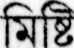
মিষ্টি
